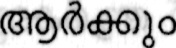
ആര്‍ക്കും
